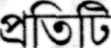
প্রতিটি
